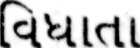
વિધાતા
